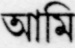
আমি
